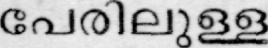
പേരിലുള്ള
